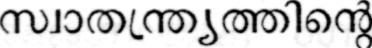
സ്വാതന്ത്ര്യത്തിന്റെ
